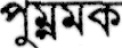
পুম্নমক
